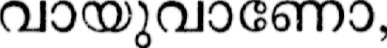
വായുവാണോ,
